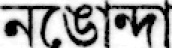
নঙোন্দা
